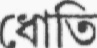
ধোতি
